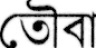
তৌবা
